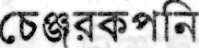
চেঞ্জরকপনি
